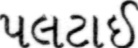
પલટાઈ
